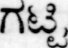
ಗಟ್ಟಿ
